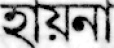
হায়না
